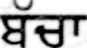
ਬੱਚਾ
